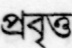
প্রবৃত্ত
